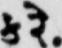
કરે.
